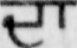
ਦਾ
